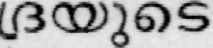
ദ്രയുടെ
